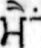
ਮੈਂ
